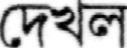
দেখল
